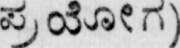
ಪ್ರಯೋಗ)
